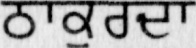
ਠਾਕੁਰਦਾ
